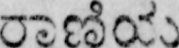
ರಾಣಿಯ
